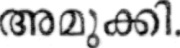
അമുക്കി.
